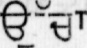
ਉੱਚਾ
